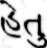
હેતુ
